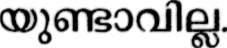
യുണ്ടാവില്ല.
